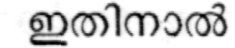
ഇതിനാല്‍
